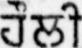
ਹੌਲੀ
